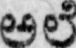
ಅಲೆ
